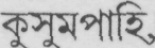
কুসুমপাহি,
